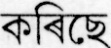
কৰিছে
